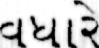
વધારે
